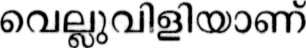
വെല്ലുവിളിയാണ്
